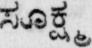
ಸೂಕ್ಷ್ಮ
